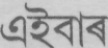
এইবাৰ
